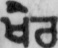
ਖੈਰ
